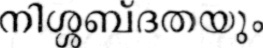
നിശ്ശബ്ദതയും
